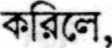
করিলে,
